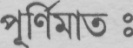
পূৰ্ণিমাতঃ
